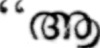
"ആ
